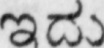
ಇದು
